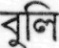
বুলি
